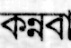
কন্নবা
